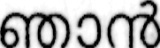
ഞാന്‍
